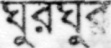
ঘুরঘুর
